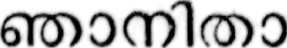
ഞാനിതാ
